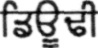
ਡਿਊਢੀ
